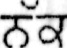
ਨੱਕ
